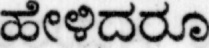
ಹೇಳಿದರೂ
